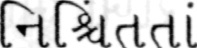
નિશ્વિંતતાં
